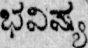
ಭವಿಷ್ಯ
